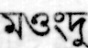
মওংদু
